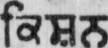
ਕਿਸ਼ਨ
